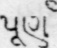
પૂર્ણ
